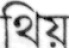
থিয়
